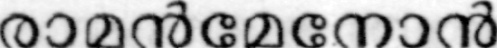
രാമന്‍മേനോന്‍
